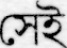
সেই
